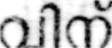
വിന്
